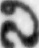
ನಿ
